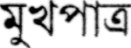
মুখপাত্র
